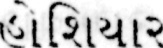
હોશિયાર
